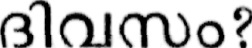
ദിവസം?
